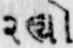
રહ્યો
